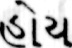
હોય
